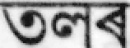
তলৰ
